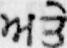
ਅਤੇ
